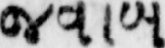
જવાબ
